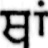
ਥਾਂ
